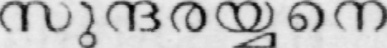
സുന്ദരയ്യനെ
